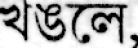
খঙলে,
